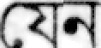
যেন
